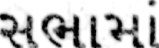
સભામાં
